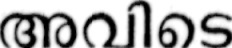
അവിടെ
